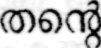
തന്റെ
